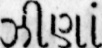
ઝીણાં
